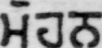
ਮੋਹਨ
